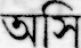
অসি
